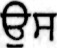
ਉਸ
